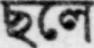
ছলে
